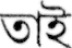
তাই
